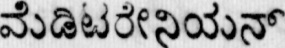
ಮೆಡಿಟರೇನಿಯನ್
